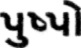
પુષ્પો
